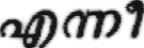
എന്നീ
